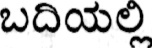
ಬದಿಯಲ್ಲಿ
